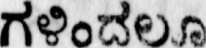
ಗಳಿಂದಲೂ
